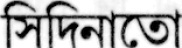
সিদিনাতো
